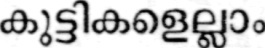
കുട്ടികളെല്ലാം
